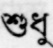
শুধু
